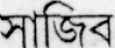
সাজিব
